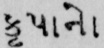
કૃપાનો
